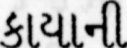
કાયાની
